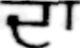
ਦਾ
